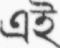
এই
